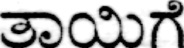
ತಾಯಿಗೆ
